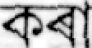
কৰা
